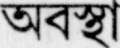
অবস্থা
